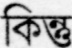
কিন্তু
